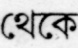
থেকে
